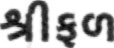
શ્રીફળ
